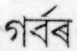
গৰ্বৰ
